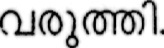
വരുത്തി.
